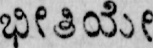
ಭೀತಿಯೇ
